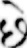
છે
